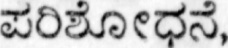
ಪರಿಶೋಧನೆ,
